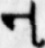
ન
